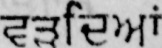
ਵੜਦਿਆਂ
